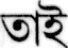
তাই
